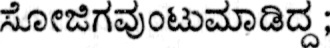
ಸೋಜಿಗವುಂಟುಮಾಡಿದ್ದ;
